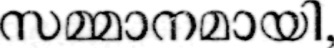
സമ്മാനമായി,
